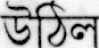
উঠিল
